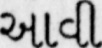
આવી
